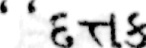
"દત્તક
